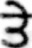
ਤੇ
